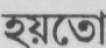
হয়তো
